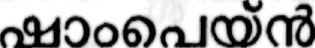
ഷാംപെയ്ന്‍
